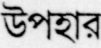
উপহার
